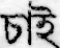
চাই
